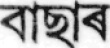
বাছাৰ
